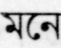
মনে
